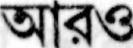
আরও
